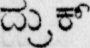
ದ್ರುಕ್
